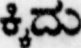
ಕ್ಕಿದು
